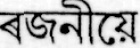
ৰজনীয়ে
